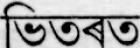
ভিতৰত
